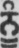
ਨੂੰ
